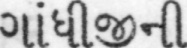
ગાંધીજીની
